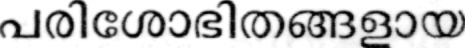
പരിശോഭിതങ്ങളായ
